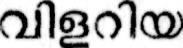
വിളറിയ
